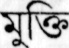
মুক্তি
